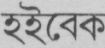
হইবেক
